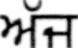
ਅੱਜ
